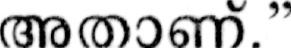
അതാണ്.”
